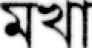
মখা
